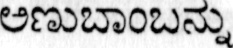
ಅಣುಬಾಂಬನ್ನು
